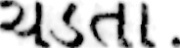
ચડતા.
